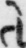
તે
